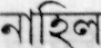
নাহিল
